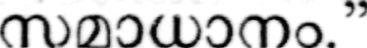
സമാധാനം."
